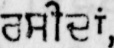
ਰਸੀਦਾਂ,
